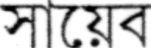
সায়েব
